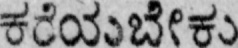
ಕರೆಯಬೇಕು
